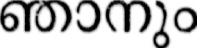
ഞാനും
